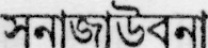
সনাজাউবনা
